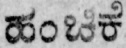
ಹಂಚಿಕೆ
